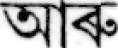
আৰু
